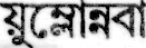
য়ুম্লোন্নবা
